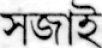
সজাই
